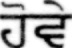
ਹੋਵੇ
